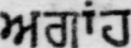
ਅਗਾਂਹ
